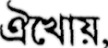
ঐখোয়,
